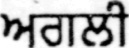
ਅਗਲੀ
